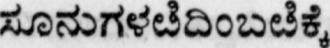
ಸೂನುಗಳೞದಿಂಬೞಕ್ಕೆ
